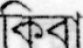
কিবা
